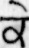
ਕੇ
